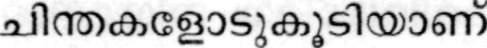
ചിന്തകളോടുകൂടിയാണ്
